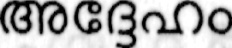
അദ്ദേഹം
